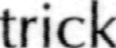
trick
